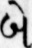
બે
